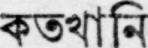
কতখানি
